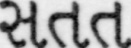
સતત
